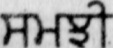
ਸਮਝੀ
